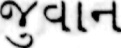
જુવાન
